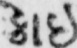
કોઈ
